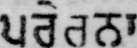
ਪਰੇਰਨਾ
